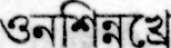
ওনশিন্নখ্রে
